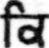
ਕਿ
